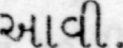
આવી.
